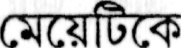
মেয়েটিকে
